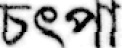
চৎপা
